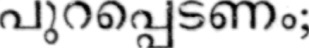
പുറപ്പെടണം;
